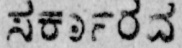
ಸರ್ಕಾರದ
